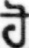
ਹੋ
